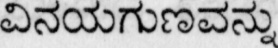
ವಿನಯಗುಣವನ್ನು
